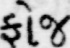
ફોજ
